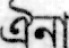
ঐনা
